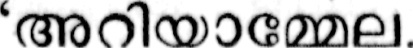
‘അറിയാമ്മേല.
